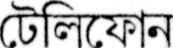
টেলিফোন
